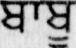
ਬਾਬੂ
